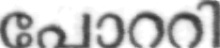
പോററി
